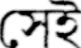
সেই
